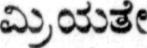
ಮ್ರಿಯತೇ
